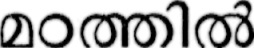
മഠത്തില്‍
